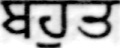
ਬਹੁਤ
